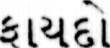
ફાયદો
